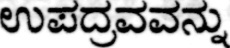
ಉಪದ್ರವವನ್ನು
